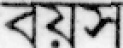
বয়স
